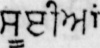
ਸੂਈਆਂ
